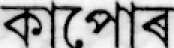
কাপোৰ
